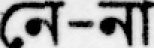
নে-না
